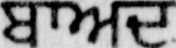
ਬਾਅਦ
